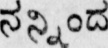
ನನ್ನಿಂದ
